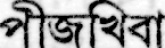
পীজখিবা
